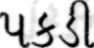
પકડી
